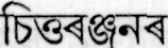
চিত্তৰঞ্জনৰ
